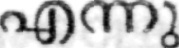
എന്നു
